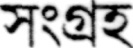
সংগ্রহ
